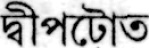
দ্বীপটোত
